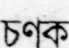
চণক
